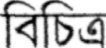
বিচিত্র
